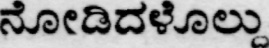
ನೋಡಿದಳೊಲ್ದು
